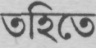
তহিতে
